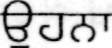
ਉਹਨਾ
